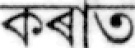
কৰাত
